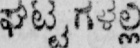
ಘಟ್ಟಗಳಲ್ಲಿ
